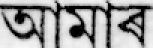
আমাৰ
